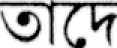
তাদে
